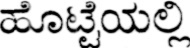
ಹೊಟ್ಟೆಯಲ್ಲಿ
